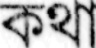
কথা
